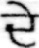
ਦੇ
